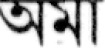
অমা
